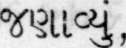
જણાવ્યું,
